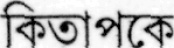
কিতাপকে
